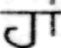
ਹਾਂ
